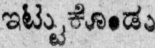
ಇಟ್ಟುಕೊಂಡು
